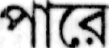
পারে
